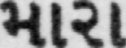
મારા
